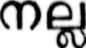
നല്ല
